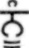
ਨੂੰ
